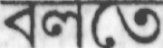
বলতে
